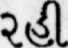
રહી
